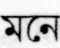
মনে
